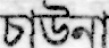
চাউনা
